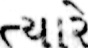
ત્યારે
